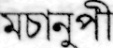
মচানুপী
